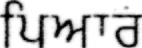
ਪਿਆਰ
